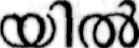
യില്‍
